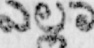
ಎಲ್ಲಾ
